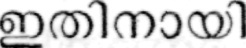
ഇതിനായി
